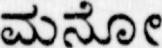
ಮನೋ
